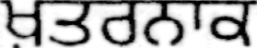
ਖ਼ਤਰਨਾਕ
